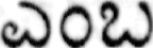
ಎಂಬ
